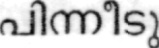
പിന്നീടു
